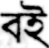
বই
